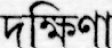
দক্ষিণা
